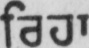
ਰਿਹਾ
